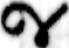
જ
